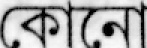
কোনো
